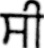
ਸੀ
